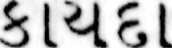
કાયદા
